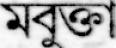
মবুক্তা
